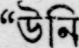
‘‘উনি
